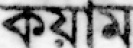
কয়াম
